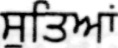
ਸੁਤਿਆਂ
